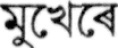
মুখেৰে
